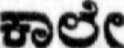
ಕಾಲೇ
